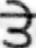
ਤੇ
